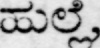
ಹುಲ್ಲೆ,
